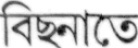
বিছনাতে
